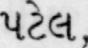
પટેલ,
